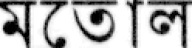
মতোল
